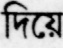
দিয়ে
